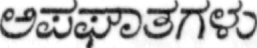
ಅಪಘಾತಗಳು
